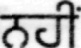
ਨਹੀਂ
